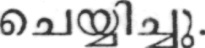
ചെയ്യിച്ചു.
